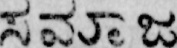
ಸಮಜ
